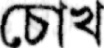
চোখ
